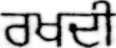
ਰਖਦੀ
